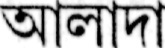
আলাদা
